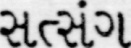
સત્સંગ
